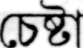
চেষ্টা
